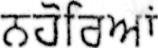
ਨਹੋਰਿਆਂ
